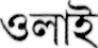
ওলাই
